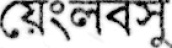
য়েংলবসু
